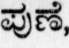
ಪುಣೆ,
